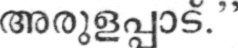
അരുളപ്പാട്."
